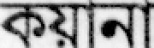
কয়ানা
